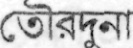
তৌরদুনা
